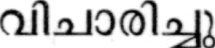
വിചാരിച്ചു
